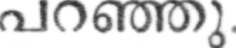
പറഞ്ഞു.
